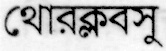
থোরক্লবসু
